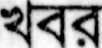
খবর
